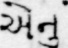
એનું
